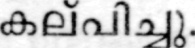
കല്പിച്ചു.
